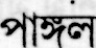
পাঙ্গল
